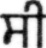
ਸੀ
